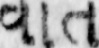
વાત
